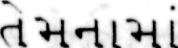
તેમનામાં
